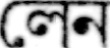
লেন
